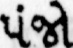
પંજો
